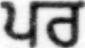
ਪਰ
